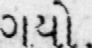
ગયો.
